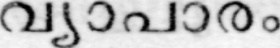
വ്യാപാരം
